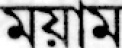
ময়াম
